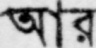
আর
